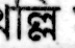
খল্লি
